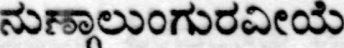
ನುಣ್ಗಾಲುಂಗುರವೀಯೆ
